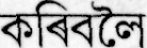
কৰিবলৈ
